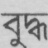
বুদ্ধ
